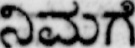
ನಿಮಗೆ
